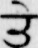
ਤੇ
